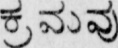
ಕ್ರಮವು
